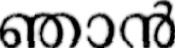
ഞാന്‍
